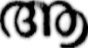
ആ
